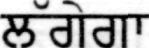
ਲੱਗੇਗਾ
